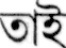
তাই
